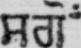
ਸਗੋਂ
